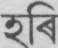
হৰি
